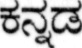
ಕನ್ನಡ
